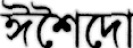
ঈশৈদো
